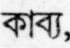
কাব্য,
